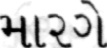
મારગે
